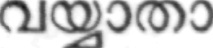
വയ്യാതാ
